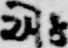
એક
